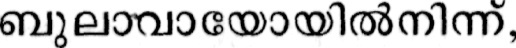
ബുലാവായോയില്‍നിന്ന്,
